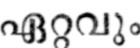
ഏറ്റവും
